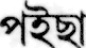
পইছা
